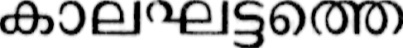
കാലഘട്ടത്തെ
